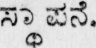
ಸ್ಥಾಪನೆ.
